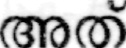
അത്
